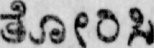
ತೋರಿಸಿ
